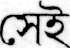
সেই
